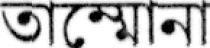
তাম্মোনা
